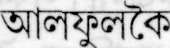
আলফুলকৈ
